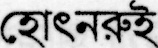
হোৎনরুই
